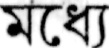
মধ্যে
